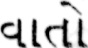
વાતો
